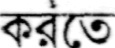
করতে
